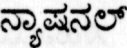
ನ್ಯಾಷನಲ್
